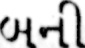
બની
